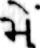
મેં
